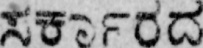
ಸರ್ಕಾರದ
